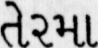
તેરમા
